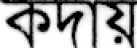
কদায়
